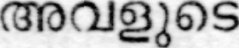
അവളുടെ
